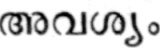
അവശ്യം
